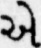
એ
